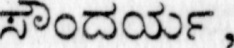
ಸೌಂದರ್ಯ,
